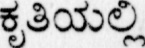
ಕೃತಿಯಲ್ಲಿ
